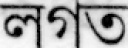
লগত
